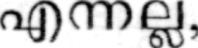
എന്നല്ല,
